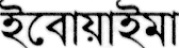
ইবোয়াইমা
